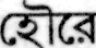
হৌরে
